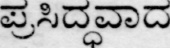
ಪ್ರಸಿದ್ಧವಾದ
